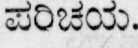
ಪರಿಚಯ.
